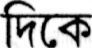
দিকে
